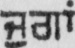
ਜੁਗਾਂ
